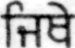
ਜਿਥੇ
